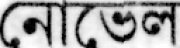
নোভেল
